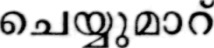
ചെയ്യുമാറ്
